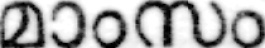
മാംസം
